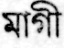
মাগী
